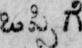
ಒಪ್ಪಿಗೆ
